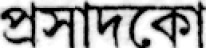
প্রসাদকো
